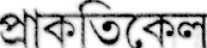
প্রাকতিকেল
